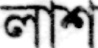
লাশ
